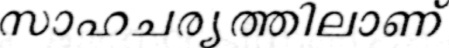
സാഹചര്യത്തിലാണ്
